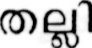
തല്ലി
